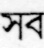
সব
